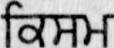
ਕਿਸਮ
